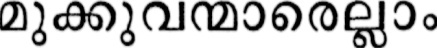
മുക്കുവന്മാരെല്ലാം
